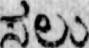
ಸಲು
